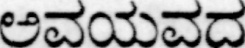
ಅವಯವದ
